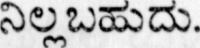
ನಿಲ್ಲಬಹುದು.
